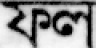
ফল
